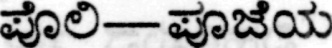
ಪೊಲಿ-ಪೂಜೆಯ
